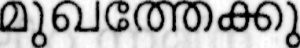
മുഖത്തേക്കു
